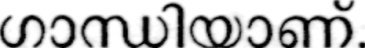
ഗാന്ധിയാണ്.
